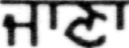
ਜਾਣਾ
